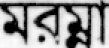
মরম্না
